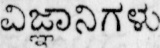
ವಿಜ್ಞಾನಿಗಳು
